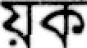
য়ক
